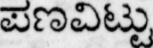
ಪಣವಿಟ್ಟು
